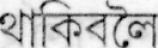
থাকিবলৈ
